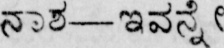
ನಾಶ-ಇವನ್ನೇ
